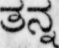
ತನ್ನ
